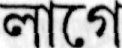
লাগে
